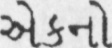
એકનો
